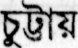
চুট্টায়
